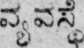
ವ್ಯವಸ್ಥೆ
